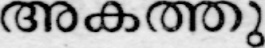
അകത്തു
